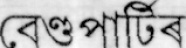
বেণ্ডপাৰ্টিৰ
